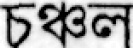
চঞ্চল
